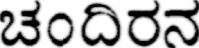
ಚಂದಿರನ
